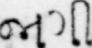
જાગી
